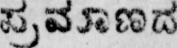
ಪ್ರಮಾಣದ
